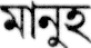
মানুহ
